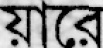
য়ারে
